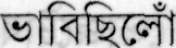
ভাবিছিলোঁ
